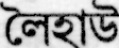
লৈহাউ
